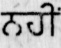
ਨਹੀਂ
